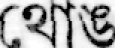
থোঙ
